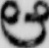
ಆ
